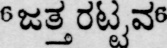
6ಜತ್ತರಟ್ಟವ6
